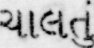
ચાલતું
